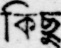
কিছু
